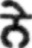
ਨੇ
